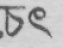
চেৎ
